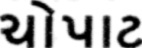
ચોપાટ
